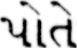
પોતે
